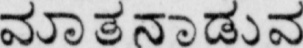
ಮಾತನಾಡುವ
